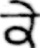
ਕੇ
